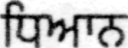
ਧਿਆਨ
